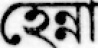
হেন্না
